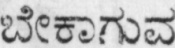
ಬೇಕಾಗುವ
